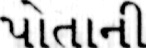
પોતાની
